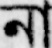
না
